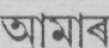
আমাৰ
